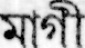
মাগী
